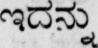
ಇದನ್ನು
